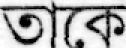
তাকে
